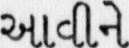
આવીને
